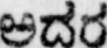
ಅದರ
